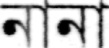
নানা
